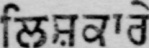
ਲਿਸ਼ਕਾਰੇ
